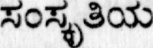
ಸಂಸ್ಕೃತಿಯ
